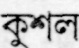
কুশল
